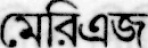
মেরিএজ
